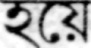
হয়ে
